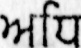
ਅਧਿ
